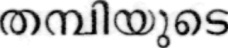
തമ്പിയുടെ
